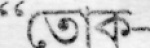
"তোক-
